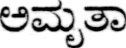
ಅಮೃತಾ
